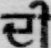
ਦੀ
